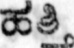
ಹತ್ತಿ
